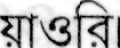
য়াওরি।
